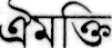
ঐমক্তি
